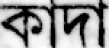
কাদা
